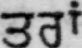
ਤਰਾਂ
